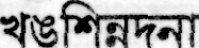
খঙশিন্নদনা
